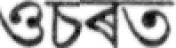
ওচৰত
